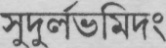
সুদুৰ্লভমিদং
